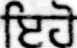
ਇਹੋ
